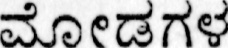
ಮೋಡಗಳ
